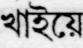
খাইয়ে
